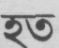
হত
